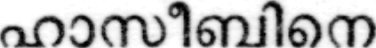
ഹാസീബിനെ
